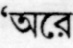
‘অরে,
